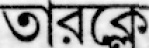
তারক্লে
